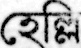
হেল্লি
